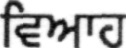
ਵਿਆਹ
